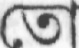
তো
